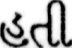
હતી
